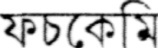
ফচকেমি
